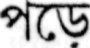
পড়ে
